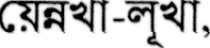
য়েন্নখা-লূখা,
